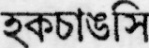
হকচাংসি
